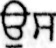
ਉਸ
